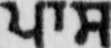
ਪਾਸ
